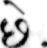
છે.
